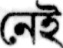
নেই
